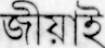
জীয়াই
